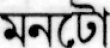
মনটো
